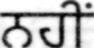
ਨਹੀਂ
